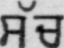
ਸੱਚ
